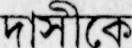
দাসীকে
